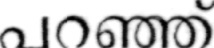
പറഞ്ഞ്
